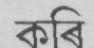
কৰি
